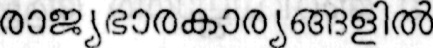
രാജ്യഭാരകാര്യങ്ങളില്‍
